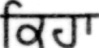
ਕਿਹਾ
